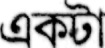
একটা
